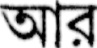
আর
